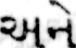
અને
